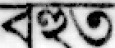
বহুত
